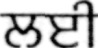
ਲਈ
